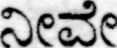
ನೀವೇ
